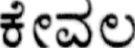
ಕೇವಲ
